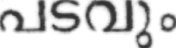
പടവും
